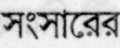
সংসারের
